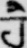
ਹੈ
